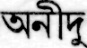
অনীদু
